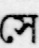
সে
